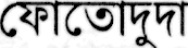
ফোতোদুদা
